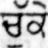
ਚੁੱਕੇ
